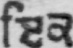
ਇਕ
